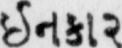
ઇનકાર
